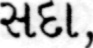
સદા,
